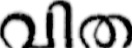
വിത
